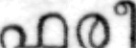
ഫരീ
